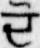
ਦੋ
